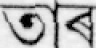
তাৰ
